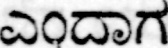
ಎಂದಾಗ
